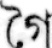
গৈ
